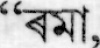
"ৰমা,
